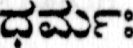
ಧರ್ಮಃ
